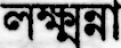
লক্ষ্মন্না
